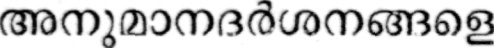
അനുമാനദര്‍ശനങ്ങളെ
